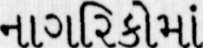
નાગરિકોમાં
